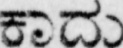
ಕಾದು
